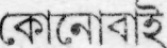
কোনোবাই
